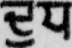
ਦੁਧ
